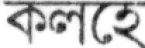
কলহে
